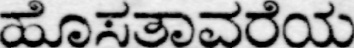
ಹೊಸತಾವರೆಯ
